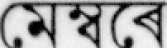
মেম্বৰে
